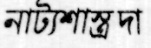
নাট্যশাস্ত্রদা
